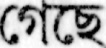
গেছে
